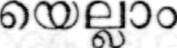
യെല്ലാം
